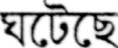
ঘটেছে
